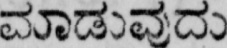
ಮಾಡುವುದು
